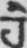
ਹੈ
